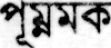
পূম্নমক
